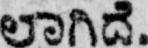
ಲಾಗಿದೆ.
